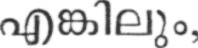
എങ്കിലും,
